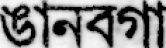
ঙানবগা
